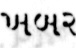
ખબર
